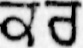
ਕਰ
